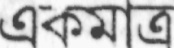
একমাত্র
